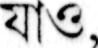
যাও,
